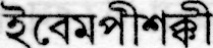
ইবেমপীশক্কী
